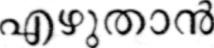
എഴുതാന്‍
